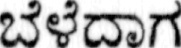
ಬೆಳೆದಾಗ
